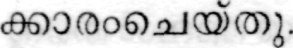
ക്കാരംചെയ്തു.
